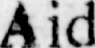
Aid
